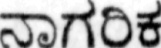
ನಾಗರಿಕ
